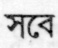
সবে
